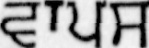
ਵਾਪਸ
